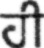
ਹੀ
